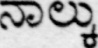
ನಾಲ್ಕು
